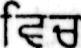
ਵਿਚ
